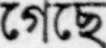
গেছে
